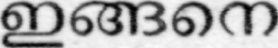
ഇങ്ങനെ
